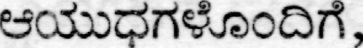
ಆಯುಧಗಳೊ೦ದಿಗೆ,
